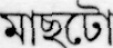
মাছটো
